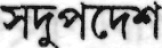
সদুপদেশ
